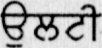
ਉਲਟੀ
